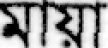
মায়া
